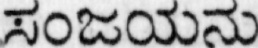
ಸಂಜಯನು
